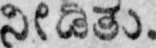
ನೀಡಿತು.
